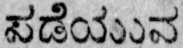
ಪಡೆಯುವ
